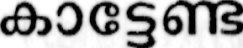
കാട്ടേണ്ട
